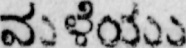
ಮಳೆಯು
